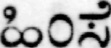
ಹಿಂಸೆ
